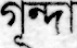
গূন্দা
